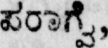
ಪರಾಗ್ವೆ,
